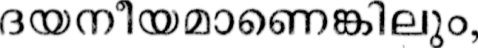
ദയനീയമാണെങ്കിലും,
